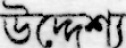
উদ্দেশ্য
